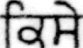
ਕਿਸੇ
